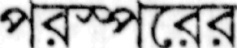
পরস্পরের
